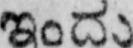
ಇಂದು
